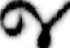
જ
